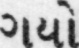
ગયો
